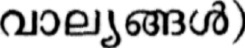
വാല്യങ്ങള്‍)
